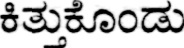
ಕಿತ್ತುಕೊಂಡು
